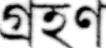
গ্রহণ
